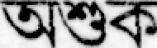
অশুক
